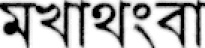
মখাথংবা
